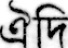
ঐদি
